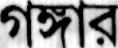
গঙ্গার
